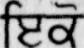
ਇਕੋ
